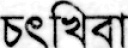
চৎখিবা
